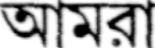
আমরা
